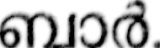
ബാര്‍.
